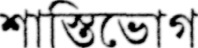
শাস্তিভোগ
